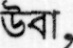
উবা,
